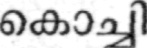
കൊച്ചി
